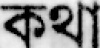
কথা
